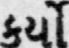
કર્યો
